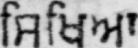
ਸਿਖਿਆ
